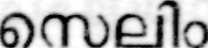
സെലിം
